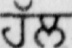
ਹੱਲ
